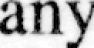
any
